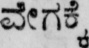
ವೇಗಕ್ಕೆ
